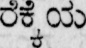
ರೆಕ್ಕೆಯ
